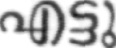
എട്ടു
